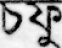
চফু
